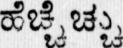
ಹೆಚ್ಚೆಚ್ಚು
